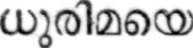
ധുരിമയെ
